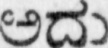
ಅದು
